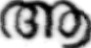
ആ
